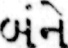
બંને
